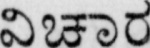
ವಿಚಾರ
